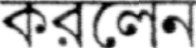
করলেন
